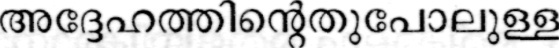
അദ്ദേഹത്തിന്റെതുപോലുള്ള
